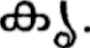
കൃ.
